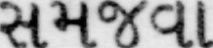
સમજવા
